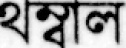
থম্বাল
